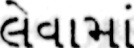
લેવામાં
